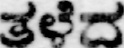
ತಳೆದ
